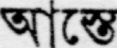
আস্তে
